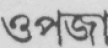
ওপজা
